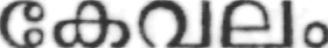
കേവലം
